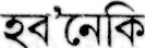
হব'নেকি
